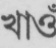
খাওঁ
